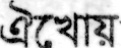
ঐখোয়
